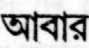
আবার
